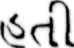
હતી
